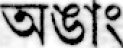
অঙাং
